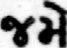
જમે
